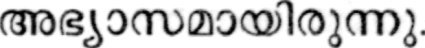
അഭ്യാസമായിരുന്നു.
